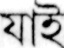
যাই
